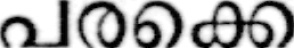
പരക്കെ
